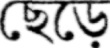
ছেড়ে
